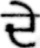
ਦੇ
